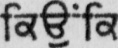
ਕਿਉਂਕਿ
